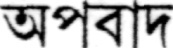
অপবাদ
